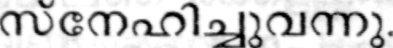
സ്നേഹിച്ചുവന്നു.
